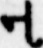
ન
